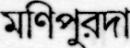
মণিপুরদা
